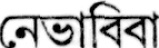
নেভাবিবা
